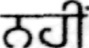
ਨਹੀਂ
